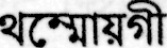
থম্মোয়গী
